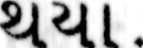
થયા.
